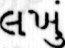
લખું
